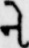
ને
